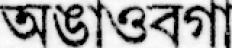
অঙাওবগা
